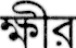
ক্ষীর
